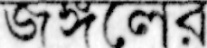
জঙ্গলের
